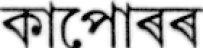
কাপোৰৰ
